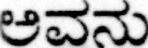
ಅವನು
